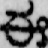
ಈ
